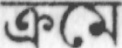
ক্রমে
